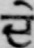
ਦੇ
